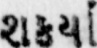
શક્યાં
